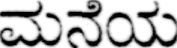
ಮನೆಯ
